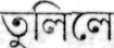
তুলিলে
